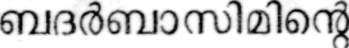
ബദര്‍ബാസിമിന്റെ
